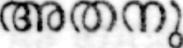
അതനു
